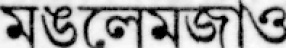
মঙলেমজাও
